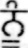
ਨੂੰ
